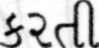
કરતી
